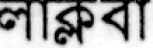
লাক্লবা
